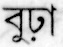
বুঢ়া
